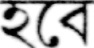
হবে
